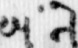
બંને
